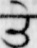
ਤੇ
